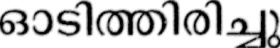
ഓടിത്തിരിച്ചു
